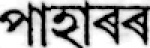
পাহাৰৰ
